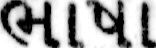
ભાષા
